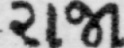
રાજા
